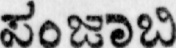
ಪಂಜಾಬಿ
